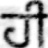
ਹੀ
